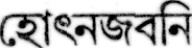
হোৎনজবনি
